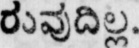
ರುವುದಿಲ್ಲ.
